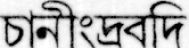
চানীংদ্রবদি
